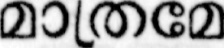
മാത്രമേ
